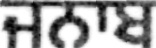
ਜਨਾਬ
